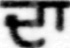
ਦਾ
